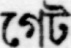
গেট
